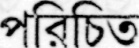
পরিচিত
